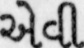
એવી
